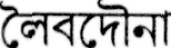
লৈবদৌনা
